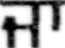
ਜਾ
